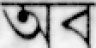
অব
